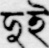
দুই
